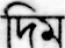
দিম
